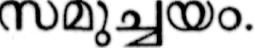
സമുച്ചയം.
